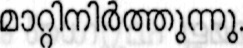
മാറ്റിനിര്‍ത്തുന്നു.
